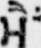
ਮੈਂ
